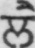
ਲੈ
